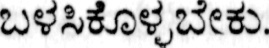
ಬಳಸಿಕೊಳ್ಳಬೇಕು.
